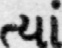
ત્યાં
